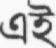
এই
